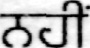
ਨਹੀਂ
